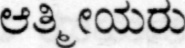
ಆತ್ಮೀಯರು
